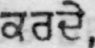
ਕਰਦੇ,
